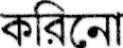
করিনো
